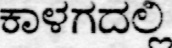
ಕಾಳಗದಲ್ಲಿ
